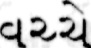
વચ્ચે
